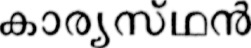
കാര്യസ്ഥന്‍
